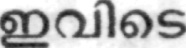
ഇവിടെ
